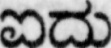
ಐದು
